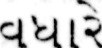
વધારે
